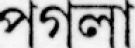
পগলা
